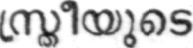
സ്ത്രീയുടെ
